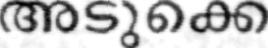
അടുക്കെ
